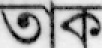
তাক
